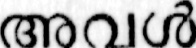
അവള്‍
